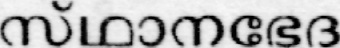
സ്ഥാനഭേദ
